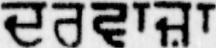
ਦਰਵਾਜ਼ਾ
